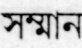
সম্মান
